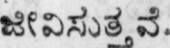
ಜೀವಿಸುತ್ತವೆ.
